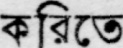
করিতে
